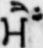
ਮੈਂ
